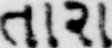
તારા
